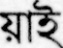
য়াই
